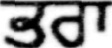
ਭਰਾ
